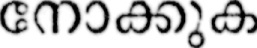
നോക്കുക
